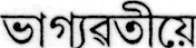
ভাগ্যৱতীয়ে
